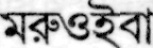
মরুওইবা
